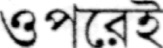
ওপরেই
